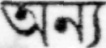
অন্য
